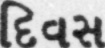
દિવસ
